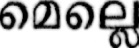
മെല്ലെ
